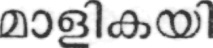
മാളികയി
